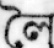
লৈ
